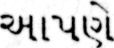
આપણે
